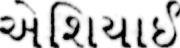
એશિયાઈ
